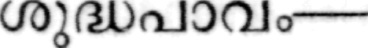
ശുദ്ധപാവം-
